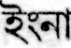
ইংনা
